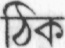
ঠিক
